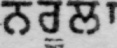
ਨਰੂਲਾ
